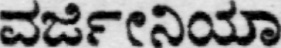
ವರ್ಜೀನಿಯಾ
